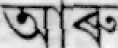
আৰু
